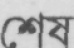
শেষ
